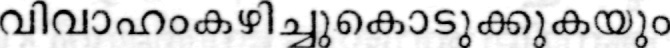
വിവാഹംകഴിച്ചുകൊടുക്കുകയും
